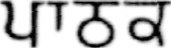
ਪਾਠਕ
